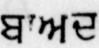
ਬਾਅਦ
